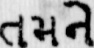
તમને
